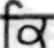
ਕਿ
